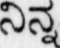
ನಿನ್ನ
